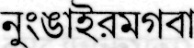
নুংঙাইরমগবা
